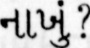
નાખું?
